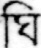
ঘি
